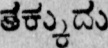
ತಕ್ಕುದು
